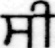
ਸੀ
